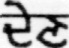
ਦੇਣ
